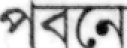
পবনে
